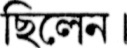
ছিলেন।
